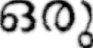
ഒരു
